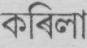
কৰিলা
